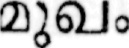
മുഖം
